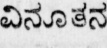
ವಿನೂತನ
